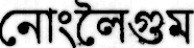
নোংলৈগুম
